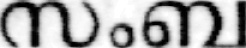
സംബ
